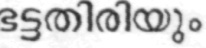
ഭട്ടതിരിയും
